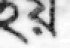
হয়
